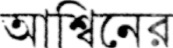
আশ্বিনের
